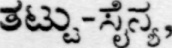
ತಟ್ಟು-ಸೈನ್ಯ,
